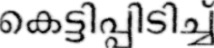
കെട്ടിപ്പിടിച്ച്
